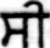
ਸੀ
